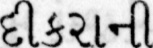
દીકરાની
